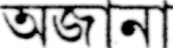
অজানা
